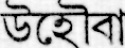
উহৌবা
